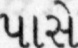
પાસે
